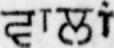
ਵਾਲਾਂ
